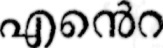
എന്റെ
